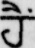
ਹੈਂ
